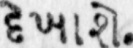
દેખાશે.
